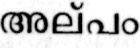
അല്പം
